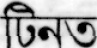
টিনত
